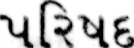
પરિષદ
